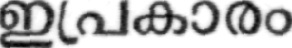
ഇപ്രകാരം
